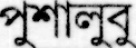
পুশালুবু
